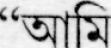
"আমি
